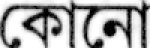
কোনো
